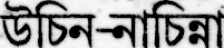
উচিন-নাচিন্না
